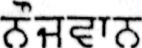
ਨੌਜਵਾਨ
